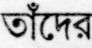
তাঁদের
